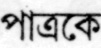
পাত্রকে
